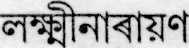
লক্ষ্মীনাৰায়ণ
